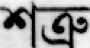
শত্রু
